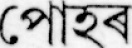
পোহৰ
